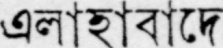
এলাহাবাদে
